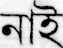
নাই
